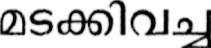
മടക്കിവച്ച
